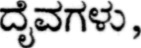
ದೈವಗಳು,
